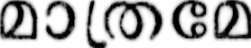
മാത്രമേ
